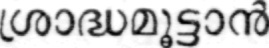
ശ്രാദ്ധമൂട്ടാന്‍
